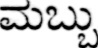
ಮಬ್ಬು
